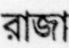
রাজা
